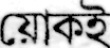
য়োকই
